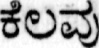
ಕೆಲವು
